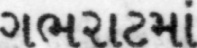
ગભરાટમાં
